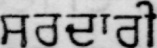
ਸਰਦਾਰੀ
